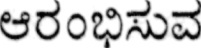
ಆರಂಭಿಸುವ
